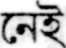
নেই
